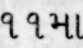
૧૧મા
